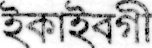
ইকাইবগী
